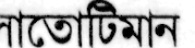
সাতোটিমান
